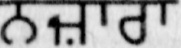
ਨਜ਼ਾਰਾ
